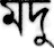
মদু
